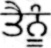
ਤੈਨੂੰ
